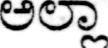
ಅಲ್ಲಾ
